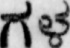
ಗಳ
